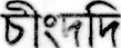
চীংদদি
